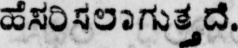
ಹೆಸರಿಸಲಾಗುತ್ತದೆ.
